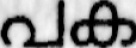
പക
